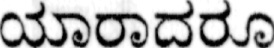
ಯಾರಾದರೂ
